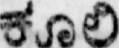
ಕೂಲಿ
